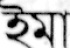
ইমা
